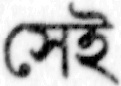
সেই
